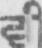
ਵੀ
